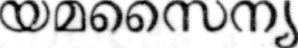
യമസൈന്യ
